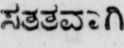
ಸತತವಾಗಿ
